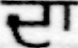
ਦਾ
